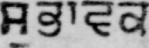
ਸੁਭਾਵਕ
